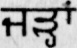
ਜੜ੍ਹਾਂ
